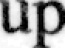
up
